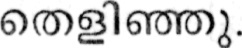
തെളിഞ്ഞു.
